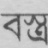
বস্ত্ৰ
